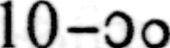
10-ാം
